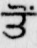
ਤੋਂ
